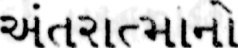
અંતરાત્માનો
